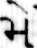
મેં
